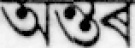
অন্তৰ
